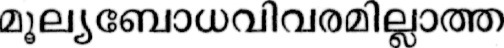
മൂല്യബോധവിവരമില്ലാത്ത
